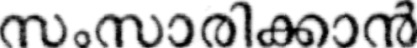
സംസാരിക്കാന്‍
